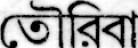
তৌরিবাল
